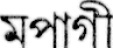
মপাগী
